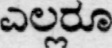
ಎಲ್ಲರೂ
